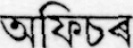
অফিচৰ
